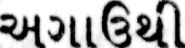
અગાઉથી
